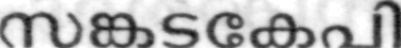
സങ്കടകേപി
